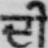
ਦੀ
